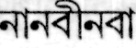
নানবীনবা
